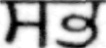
ਸਭ
